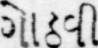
ગોઠવી
